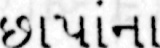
છાપાંના
